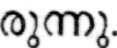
രുന്നു.
